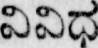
ವಿವಿಧ
